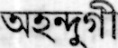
অহন্দুগী
